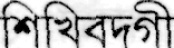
শিখিবদগী
